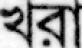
খরা
